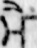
ਮੈਂ
